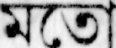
মতো
